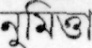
নুমিত্তা
